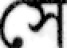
সে
